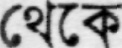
থেকে
